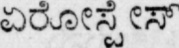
ಏರೋಸ್ಪೇಸ್
